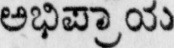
ಅಭಿಪ್ರಾಯ
